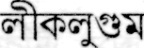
লীকলুগুম
